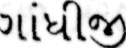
ગાંધીજી
